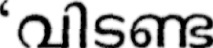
‘വിടണ്ട
